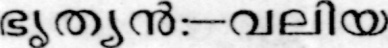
ഭൃത്യന്‍:-വലിയ
